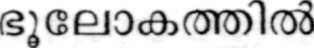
ഭൂലോകത്തില്‍
